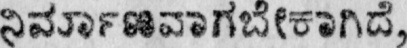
ನಿರ್ಮಾಣವಾಗಬೇಕಾಗಿದೆ,
